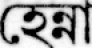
হেন্না
